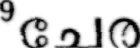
9ചേര
